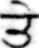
ਤੇ
